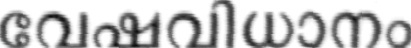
വേഷവിധാനം
